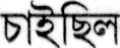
চাইছিল
